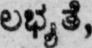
ಲಭ್ಯತೆ,
